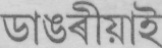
ডাঙৰীয়াই
